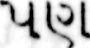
પણ
